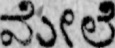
ಮೇಲೆ
